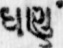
ધણું
